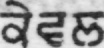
ਕੇਵਲ
